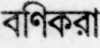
বণিকরা
